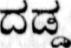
ದಡ್ಡ
